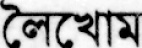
লৈখোম
